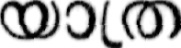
യാത്ര
